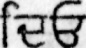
ਦਿਓ
